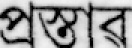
প্রস্তাৱ
